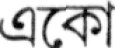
একো
